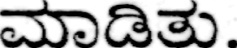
ಮಾಡಿತು.
